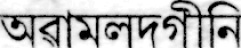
অৱামলদগীনি
